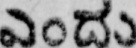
ಎಂದು
